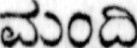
ಮಂದಿ
